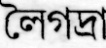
লৈগদ্রা
